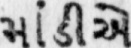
માંડીએ
